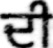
ਦੀ
